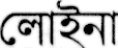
লোইনা
